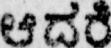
ಆದರೆ
